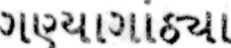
ગણ્યાગાંઠ્યા
